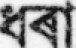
ধৰা
